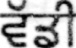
ਵੱਡੀ
